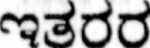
ಇತರರ
